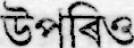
উপৰিও
